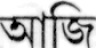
আজি
